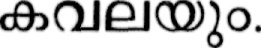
കവലയും.
